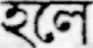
হলে
